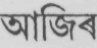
আজিৰ
